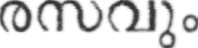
രസവും
